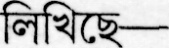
লিখিছে-
